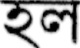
হল
